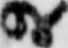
જ
